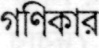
গণিকার
